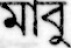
মাবু
